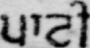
ਪਾਟੀ
